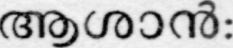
ആശാന്‍:
